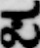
ಪ
